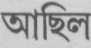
আছিল
